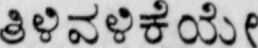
ತಿಳಿವಳಿಕೆಯೇ
